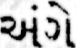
અંગે
